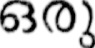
ഒരു
